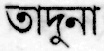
তাদুনা
